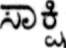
ಸಾಕ್ಷಿ
